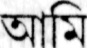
আমি
